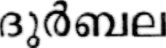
ദുര്‍ബല
